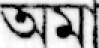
অমা
